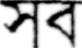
সব
